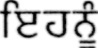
ਇਹਨੂੰ
